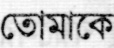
তোমাকে
